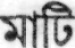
মাটি
